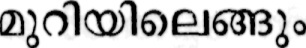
മുറിയിലെങ്ങും
